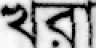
খরা
